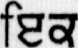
ਇਕ
